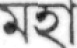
মহা
